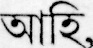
আহি,
